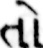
તો
